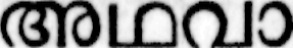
അഥവാ
